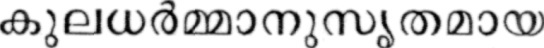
കുലധര്‍മ്മാനുസൃതമായ
